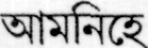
আমনিহে
